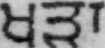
ਖੜਾ
